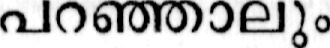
പറഞ്ഞാലും
